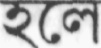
হলে
